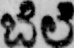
ಬೆಲೆ
